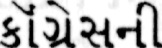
કૉંગ્રેસની
